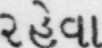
રહેવા
